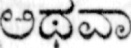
ಅಥವಾ
